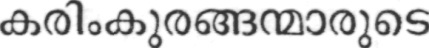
കരിംകുരങ്ങന്മാരുടെ
